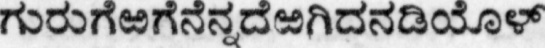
ಗುರುಗೆಱಗೆನೆನ್ನದೆಱಗಿದನಡಿಯೊಳ್
